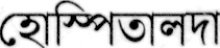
হোস্পিতালদা
